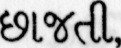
છાજતી,
